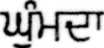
ਘੁੰਮਦਾ
